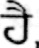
ਹੈ,
